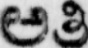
ಅತಿ
